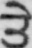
ਤੇ
